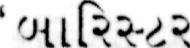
'બારિસ્ટર
